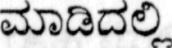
ಮಾಡಿದಲ್ಲಿ
